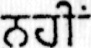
ਨਹੀਂ
